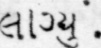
લાગ્યું.
